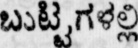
ಬುಟ್ಟಿಗಳಲ್ಲಿ
